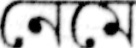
নেমে
